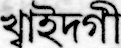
খ্বাইদগী
